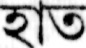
হাত
